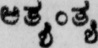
ಅತ್ಯಂತ್ಯ
